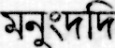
মনুংদদি
